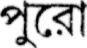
পুরো
